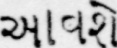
આવશે
